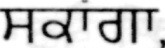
ਸਕਾਂਗਾ,
